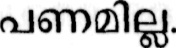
പണമില്ല.
